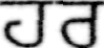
ਹਰ
